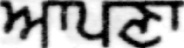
ਆਪਣਾ
